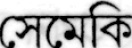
সেমেকি
